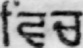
ਵਿਚ
